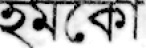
হমকো
